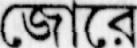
জোরে
